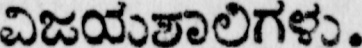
ವಿಜಯಶಾಲಿಗಳು.
